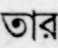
তার
